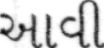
આવી
